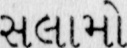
સલામો
